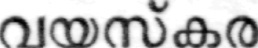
വയസ്കര
